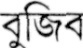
বুজিব
